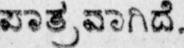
ಪಾತ್ರವಾಗಿದೆ.
